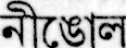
নীঙোল
